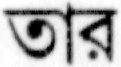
তার
